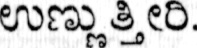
ಉಣ್ಣುತ್ತೀರಿ.
